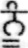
ਨੂੰ
